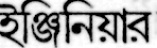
ইঞ্জিনিয়ার
